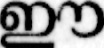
ഈ
